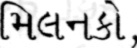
મિલનકો,
